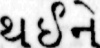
થઈને
